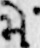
મેં
